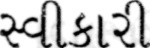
સ્વીકારી
